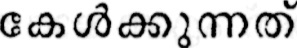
കേള്‍ക്കുന്നത്
